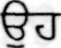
ਉਹ
